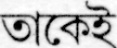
তাকেই
